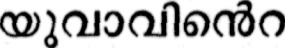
യുവാവിന്റെ
